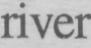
river
